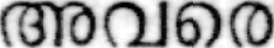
അവരെ
